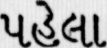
પહેલા
